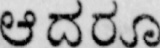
ಆದರೂ
